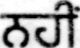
ਨਹੀਂ
